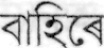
বাহিৰে
